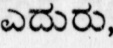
ಎದುರು,
